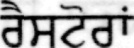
ਰੈਸਟੋਰਾਂ
